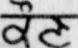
ਕੌਣ
